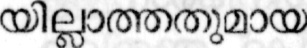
യില്ലാത്തതുമായ
